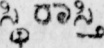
ಸ್ಥಿರಾಸ್ತಿ
